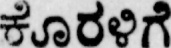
ಕೊರಳಿಗೆ
